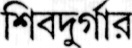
শিবদুর্গার
